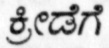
ಕ್ರೀಡೆಗೆ
